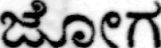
ಜೋಗ
